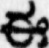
ಈ
